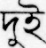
দুই
